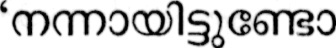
'നന്നായിട്ടുണ്ടോ
